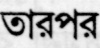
তারপর
